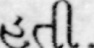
હતી.
